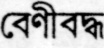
বেণীবদ্ধ
